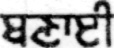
ਬਣਾਈ
